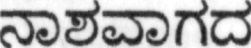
ನಾಶವಾಗದ
